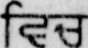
ਵਿਚ
